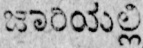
ಜಾರಿಯಲ್ಲಿ
